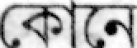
কোনে
